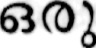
ഒരു
